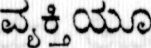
ವ್ಯಕ್ತಿಯೂ
